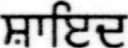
ਸ਼ਾਇਦ
